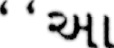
"આ
